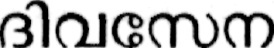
ദിവസേന
